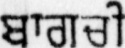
ਬਾਗਚੀ
